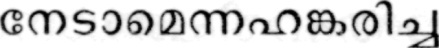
നേടാമെന്നഹങ്കരിച്ച
